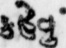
કહેવું
